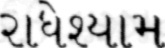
રાધેશ્યામ
